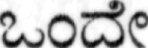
ಒಂದೇ
